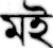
মই
